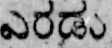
ಎರಡು
